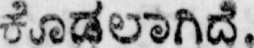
ಕೊಡಲಾಗಿದೆ.
